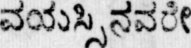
ವಯಸ್ಸಿನವರೇ
